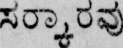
ಸರ್‍ಕಾರವು
